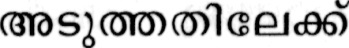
അടുത്തതിലേക്ക്
